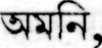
অমনি,
